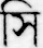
সি
